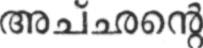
അച്ഛന്റെ
